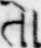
તો
